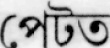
পেটত
